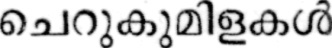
ചെറുകുമിളകള്‍
